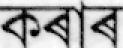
কৰাৰ
